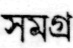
সমগ্র
